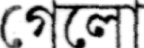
গেলো
